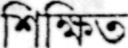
শিক্ষিত
